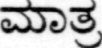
ಮಾತ್ರ
